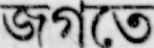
জগতে
